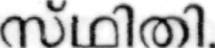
സ്ഥിതി.
